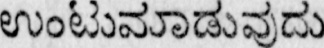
ಉಂಟುಮಾಡುವುದು
